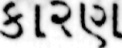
કારણ
